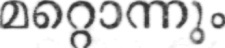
മറ്റൊന്നും
